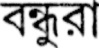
বন্ধুরা
